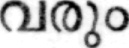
വരും
